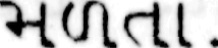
મળતા.
